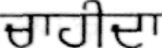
ਚਾਹੀਦਾ
